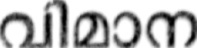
വിമാന
